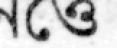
নত্তে
